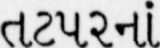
તટપરનાં
